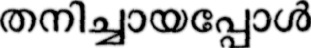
തനിച്ചായപ്പോള്‍
